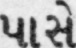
પાસે
